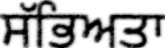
ਸੱਭਿਅਤਾ
